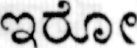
ಇರೋ
